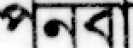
পনবা
